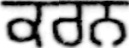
ਕਰਨ
